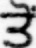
ਤੋਂ
